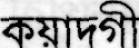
কয়াদগী
